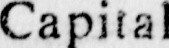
Capital
